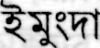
ইমুংদা
